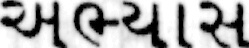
અભ્યાસ
